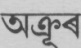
অক্ৰূৰ
